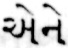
એને
